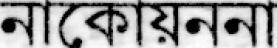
নাকোয়ননা
